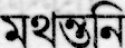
মথন্তনি
